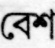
বেশ
